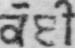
ਕੋਈ
